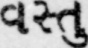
વસ્તુ
